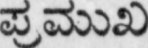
ಪ್ರಮುಖ
